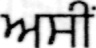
ਅਸੀਂ
